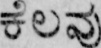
ಕೆಲವು
